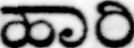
ಹಾರಿ
